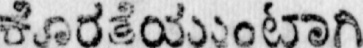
ಕೊರತೆಯುಂಟಾಗಿ
